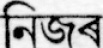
নিজৰ
